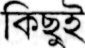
কিছুই
